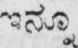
ಇನ್ನೂ
